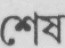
শেষ
